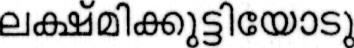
ലക്ഷ്മിക്കുട്ടിയോടു
